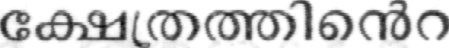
ക്ഷേത്രത്തിന്റെ
